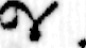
જ.
